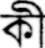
কী
